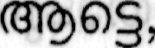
ആട്ടെ,
